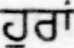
ਹੁਰਾਂ
